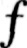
f
